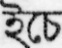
ইচে
